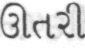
ઊતરી
